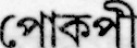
পোকপী
